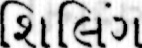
શિલિંગ
